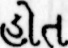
હોત
